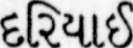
દરિયાઈ
